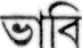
ভাবি
